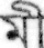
মী
